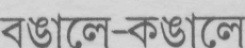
বঙালে-কঙালে
